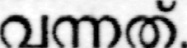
വന്നത്.
